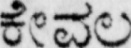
ಕೇವಲ
